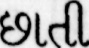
છાતી
